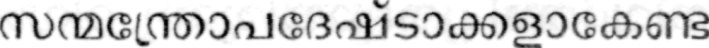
സന്മന്ത്രോപദേഷ്ടാക്കളാകേണ്ട
